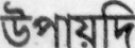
উপায়দি
